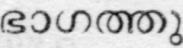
ഭാഗത്തു
